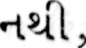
નથી,
